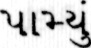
પામ્યું
